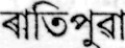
ৰাতিপুৱা
